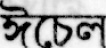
ঈচেল
